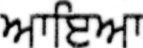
ਆਇਆ
